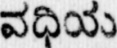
ವಧಿಯ
